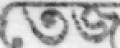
তেজ
